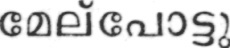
മേല്പോട്ടു
